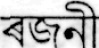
ৰজনী
